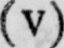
(v)
